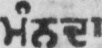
ਮੰਨਦਾ
